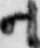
ન
